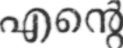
എന്റെ
